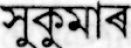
সুকুমাৰ
